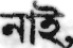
নাই,
